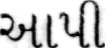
આપી
